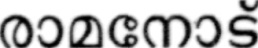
രാമനോട്
